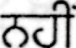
ਨਹੀਂ
